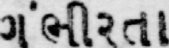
ગંભીરતા
